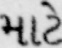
માટે
